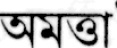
অমত্তা
